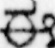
ಈ
